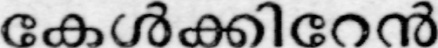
കേള്‍ക്കിറേന്‍
